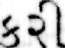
કરી
